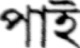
পাই
